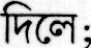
দিলে;
